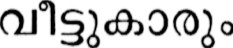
വീട്ടുകാരും
